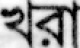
খরা
